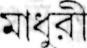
মাধুরী
